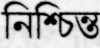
নিশ্চিন্ত
